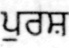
ਪੁਰਸ਼
